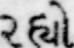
રહ્યો
